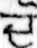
ਦੋ
